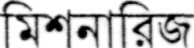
মিশনারিজ
